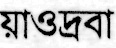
য়াওদ্রবা
